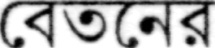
বেতনের
